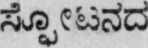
ಸ್ಫೋಟನದ
